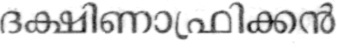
ദക്ഷിണാഫ്രിക്കന്‍
